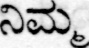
ನಿಮ್ಮ
